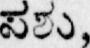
ಪಶು,
